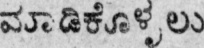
ಮಾಡಿಕೊಳ್ಳಲು
